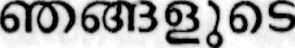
ഞങ്ങളുടെ
